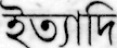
ইত্যাদি
